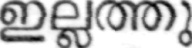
ഇല്ലത്തു
